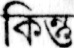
কিন্তু
